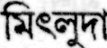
মিৎলুদা
